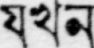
যখন
